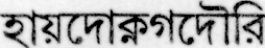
হায়দোক্নগদৌরি
